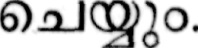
ചെയ്യും.
